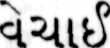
વેચાઈ
